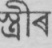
স্ত্রীৰ
